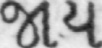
જાય
